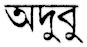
অদুবু
